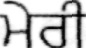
ਮੇਰੀ
